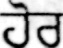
ਹੋਰ
